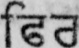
ਫਿਰ
